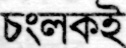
চংলকই
